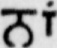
ਨਾਂ
